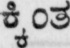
ಕ್ಕಿಂತ
